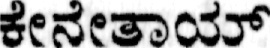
ಕೇನೇತಾಯ್
